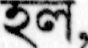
হল,
